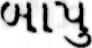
બાપુ
